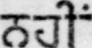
ਨਹੀਂ
